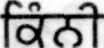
ਕਿੰਨੀ
